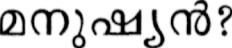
മനുഷ്യന്‍?
